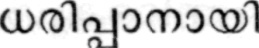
ധരിപ്പാനായി
